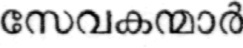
സേവകന്മാര്‍
